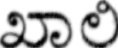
ಖಾಲಿ
